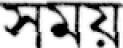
সময়
